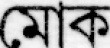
মোক
